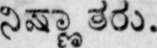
ನಿಷ್ಣಾತರು.
